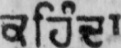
ਕਹਿੰਦਾ
